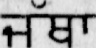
ਜੱਥਾ
